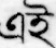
এই
